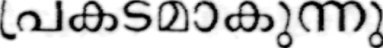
പ്രകടമാകുന്നു
